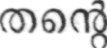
തന്റെ
